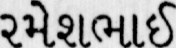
રમેશભાઈ
